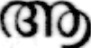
ആ
